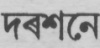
দৰশনে
